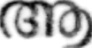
ആ
